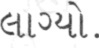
લાગ્યો.
